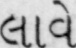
લાવે
